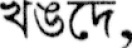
খঙদে,
